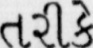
તરીકે
